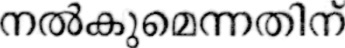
നല്‍കുമെന്നതിന്
